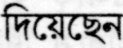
দিয়েছেন
